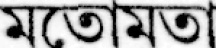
মতোমতা
